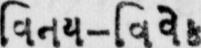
વિનય-વિવેક
